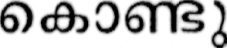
കൊണ്ടു
